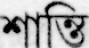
শান্তি
